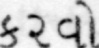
કરવો
